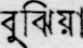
বুঝিয়া
